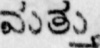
ಮತ್ತು
